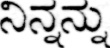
ನಿನ್ನನ್ನು
